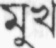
মুখ
